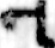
ન
